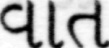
વાત
